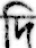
দি
